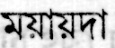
ময়ায়দা
